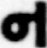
ન
